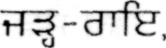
ਜੜ੍ਹ-ਰਾਇ,
